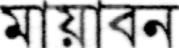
মায়াবন
